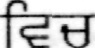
ਵਿਚ
